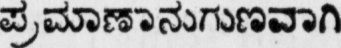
ಪ್ರಮಾಣಾನುಗುಣವಾಗಿ
